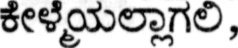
ಕೇಳ್ಮೆಯಲ್ಲಾಗಲಿ,
